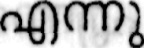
എന്നു
